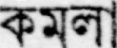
কমলা
